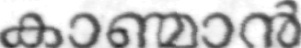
കാണ്മാന്‍
